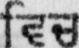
ਵਿਚ
